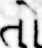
તો
